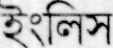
ইংলিস
